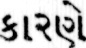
કારણે
